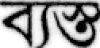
ব্যস্ত
